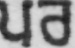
ਪਰ
